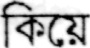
কিয়ে
